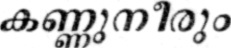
കണ്ണുനീരും
